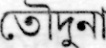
তৌদুনা
